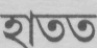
হাতত
